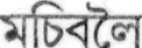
মচিবলৈ
